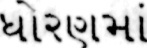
ધોરણમાં
